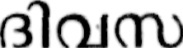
ദിവസ
